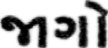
જાગો
